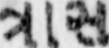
ત્રાસ
